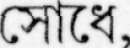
সোধে,
